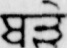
ਬੜੇ
